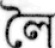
লৈ
